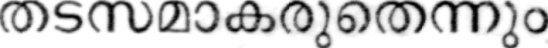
തടസമാകരുതെന്നും
